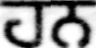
ਹਨ
